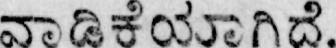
ವಾಡಿಕೆಯಾಗಿದೆ.
